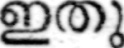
ഇതു
